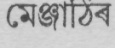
মেঞ্জাঠিৰ
